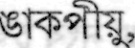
ঙাকপীয়ু,
